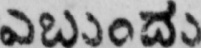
ಎಂಬುದು
